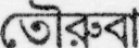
তৌরুবা
